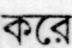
করে
